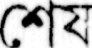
শেষ
